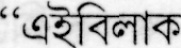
"এইবিলাক
